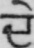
ਦੇ
